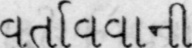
વર્તાવવાની
